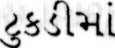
ટુકડીમાં
